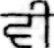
ਵੀ
